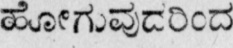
ಹೋಗುವುದರಿಂದ
